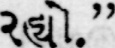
રહ્યો."
